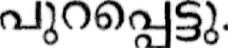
പുറപ്പെട്ടു.
